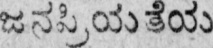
ಜನಪ್ರಿಯತೆಯ
